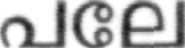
പലേ
